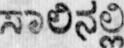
ಸಾಲಿನಲ್ಲಿ
